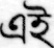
এই
